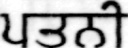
ਪਤਨੀ
